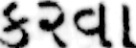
કરવા
